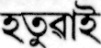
হতুৱাই
